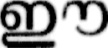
ഈ
